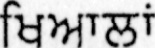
ਖਿਆਲਾਂ
